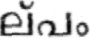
ല്പം
